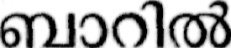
ബാറില്‍
